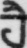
ਹੈ
